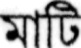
মাটি
